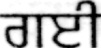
ਗਈ
